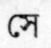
সে
